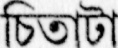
চিতাটা
